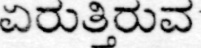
ಏರುತ್ತಿರುವ
